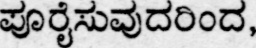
ಪೂರೈಸುವುದರಿಂದ,
